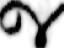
જ
